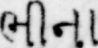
ભીના
